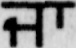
ਜਾ
